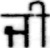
ਜੀ
